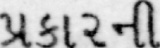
પ્રકારની
